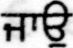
ਜਾਉ
